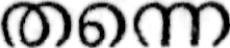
തന്നെ
